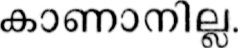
കാണാനില്ല.
